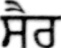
ਸੈਰ
